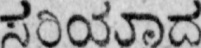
ಸರಿಯಾದ
